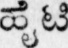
ಹೈಟಿ
